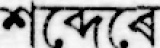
শব্দেৰে
